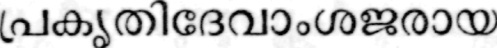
പ്രകൃതിദേവാംശജരായ
